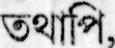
তথাপি,
